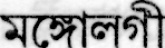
মঙ্গোলগী
